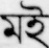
মই
